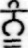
ਨੂੰ
